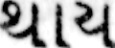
થાય
